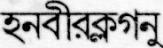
হনবীরক্লগনু
